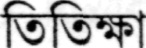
তিতিক্ষা
